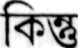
কিন্তু
